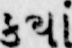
ક્યાં
